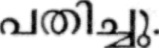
പതിച്ചു.
